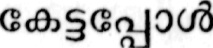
കേട്ടപ്പോള്‍
